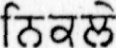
ਨਿਕਲੇ
